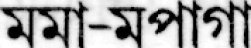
মমা-মপাগা
